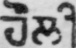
ਹੌਲੀ
